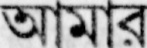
আমার
